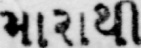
મારાથી
